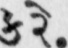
કરે.
